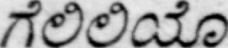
ಗೆಲಿಲಿಯೊ
